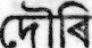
দৌৰি
